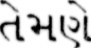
તેમણે
